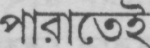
পারাতেই
